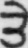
ਤੇ
